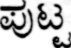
ಪುಟ್ಟ
